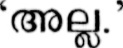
‘അല്ല.’
